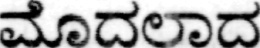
ಮೊದಲಾದ
